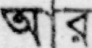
আর
